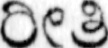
ರೀತಿ
